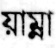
য়াম্না
